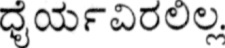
ಧೈರ್ಯವಿರಲಿಲ್ಲ.
